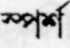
স্পর্শ
